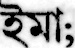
ইমা;
